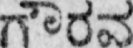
ಗೌರವ
